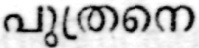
പുത്രനെ
